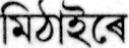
মিঠাইৰে
